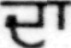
ਦਾ
